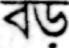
বড়
